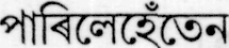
পাৰিলেহেঁতেন
